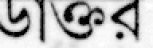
ডাক্তর
